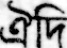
ঐদি
